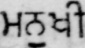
ਮਨੁਖੀ
